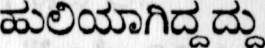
ಹುಲಿಯಾಗಿದ್ದದ್ದು
